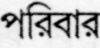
পরিবার
